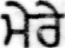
ਮੇਰੇ
